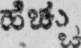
ಹೆಚ್ಚು
